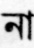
না
